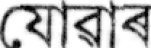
যোৱাৰ
